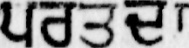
ਪਰਤਦਾ
